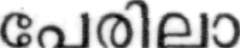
പേരിലാ
